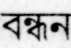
বন্ধন
